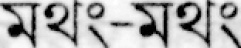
মথং-মথং
